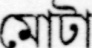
মোটা
